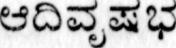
ಆದಿವೃಷಭ
